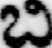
ಬಿ
